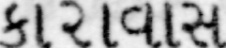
કારાવાસ
